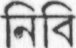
নিবি
